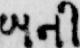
બની
